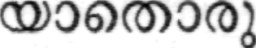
യാതൊരു
